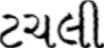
ટચલી
